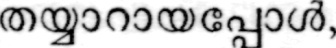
തയ്യാറായപ്പോള്‍,
